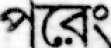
পরেং
